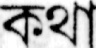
কথা
